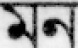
মন
